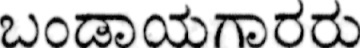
ಬಂಡಾಯಗಾರರು
